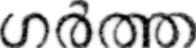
ഗര്‍ത്ത
